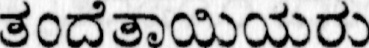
ತಂದೆತಾಯಿಯರು
